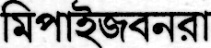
মিপাইজবনরা
